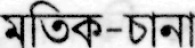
মতিক-চানা
